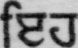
ਇਹ
